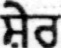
ਸ਼ੇਰ
